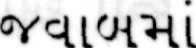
જવાબમાં
